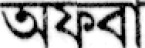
অফবা
